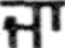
ਜਾ
